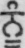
ਨੂੰ
